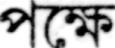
পক্ষে
